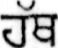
ਹੱਥ
